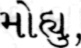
મોહ્યુ,
